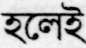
হলেই
